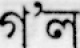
গ'ল
